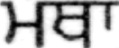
ਮਥਾ
